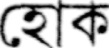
হোক
